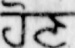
ਹੋਣ
